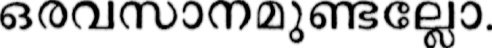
ഒരവസാനമുണ്ടല്ലോ.
